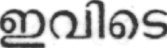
ഇവിടെ
